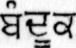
ਬੰਦੂਕ
